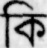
কি
